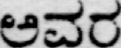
ಅವರ
